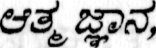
ಆತ್ಮಜ್ಞಾನ,
